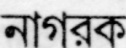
নাগরক
